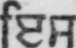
ਇਸ
